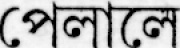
পেলালে
